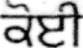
ਕੋਈ
